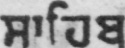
ਸਾਹਿਬ
